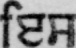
ਇਸ
